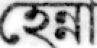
হেন্না
